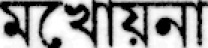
মখোয়না
